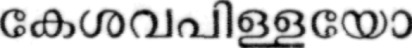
കേശവപിള്ളയോ
